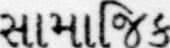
સામાજિક
